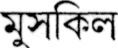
মুসকিল
